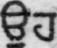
ਉਹ
